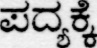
ಪದ್ಯಕ್ಕೆ
